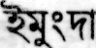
ইমুংদা
